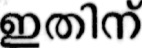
ഇതിന്
